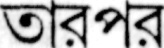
তারপর
